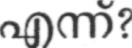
എന്ന്?
